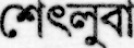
শেৎলুবা
